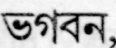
ভগবন,
